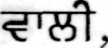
ਵਾਲੀ,
